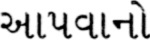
આપવાનો
